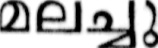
മലച്ചു
